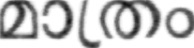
മാത്രം
